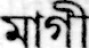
মাগী
